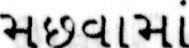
મછવામાં
